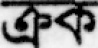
ক্রক
